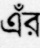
এঁর
